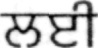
ਲਈ
